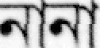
নানা
